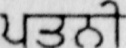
ਪਤਨੀ
